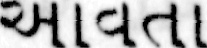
આવતા
